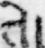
તો
